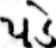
પડે
